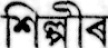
শিল্পীৰ
